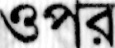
ওপর
